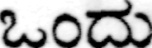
ಒಂದು
